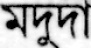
মদুদা
